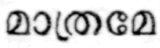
മാത്രമേ
